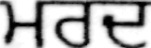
ਮਰਦ
